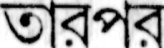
তারপর
